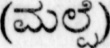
(ಮಲ್ಪೆ)
